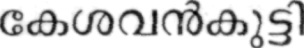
കേശവന്‍കുട്ടി
